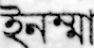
ইনম্মা
